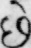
છે
